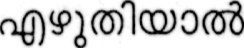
എഴുതിയാല്‍
